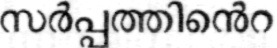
സര്‍പ്പത്തിന്റെ
